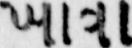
ખાવા
